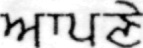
ਆਪਣੇ
